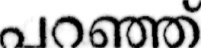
പറഞ്ഞ്
